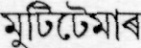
মুটিটেমাৰ
